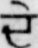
ਦੇ
